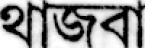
থাজবা
